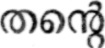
തന്റെ
